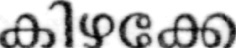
കിഴക്കേ
